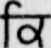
ਕਿ
